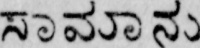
ಸಾಮಾನು
